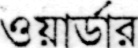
ওয়ার্ডার
